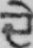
ਦੇ
